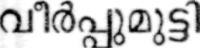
വീര്‍പ്പുമുട്ടി
